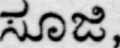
ಸೂಜಿ,
